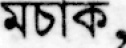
মচাক,
